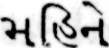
મહિને
